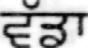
ਵੱਡਾ
